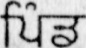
ਪਿੰਡ
